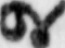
જ
